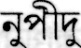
নুপীদু
